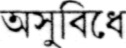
অসুবিধে
